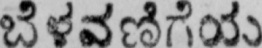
ಬೆಳವಣಿಗೆಯ
